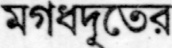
মগধদূতের
